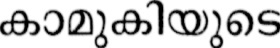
കാമുകിയുടെ
